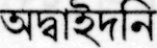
অদ্বাইদনি
